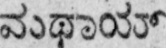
ಮಥಾಯ್
